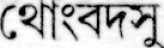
থোংবদসু
